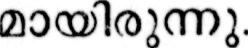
മായിരുന്നു.
